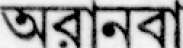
অরানবা
